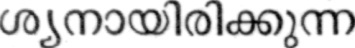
ശ്യനായിരിക്കുന്ന
